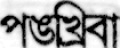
পঙখ্রিবা
